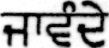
ਜਾਵੰਦੇ
